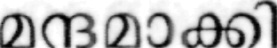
മന്ദമാക്കി
